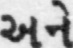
અને
